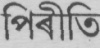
পিৰীতি
